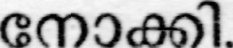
നോക്കി.
